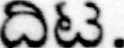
ದಿಟ.
